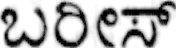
ಬರೀಸ್
